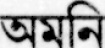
অমনি
